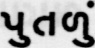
પુતળું
